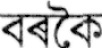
বৰকৈ
